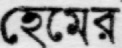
হেমের
